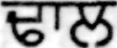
ਢਾਲ
